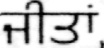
ਜੀਤਾਂ,
